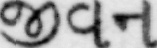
જીવન
